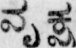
ವೃಕ್ಷ
